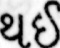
થઈ
